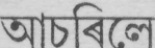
আচৰিলে
